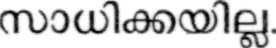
സാധിക്കയില്ല.
